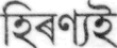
হিৰণ্যই
